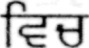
ਵਿਚ
